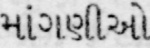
માંગણીઓ
